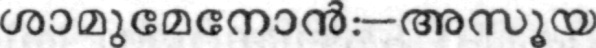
ശാമുമേനോന്‍:-അസൂയ
